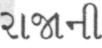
રાજાની
